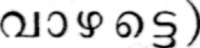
വാഴട്ടെ)
